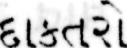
દાકતરો
